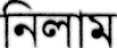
নিলাম
